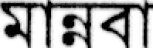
মান্নবা
